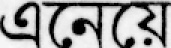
এনেয়ে
